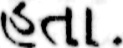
હતા.
